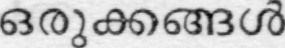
ഒരുക്കങ്ങള്‍
